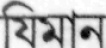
যিমান
